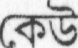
কেউ
